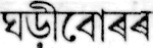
ঘড়ীবোৰৰ
